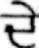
ਦੇ
